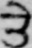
ਤੇ
